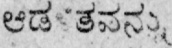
ಆಡಳಿತವನ್ನು
